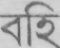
বহি
